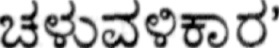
ಚಳುವಳಿಕಾರ'
